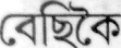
বেছিকৈ
